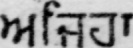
ਅਜਿਹਾ
